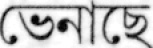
ভেনাছে
